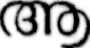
ആ
